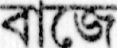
বাজে
